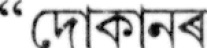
"দোকানৰ
